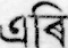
এৰি
